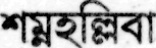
শম্নহল্লিবা
